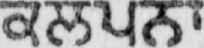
ਕਲਪਨਾ
